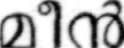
മീന്‍
